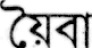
য়ৈবা
